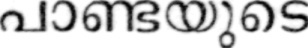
പാണ്ടയുടെ
